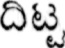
ದಿಟ್ಟ
